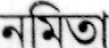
নমিতা
